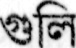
গুলি
